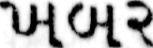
ખબર
